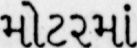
મોટરમાં
